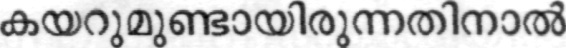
കയറുമുണ്ടായിരുന്നതിനാല്‍
